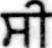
ਸੀ
